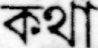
কথা
